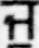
ਜੁ
